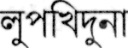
লুপখিদুনা
